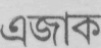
এজাক
